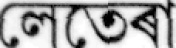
লেতেৰা
